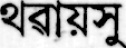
থৱায়সু
